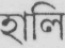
হালি
